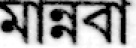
মান্নবা
